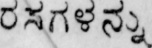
ರಸಗಳನ್ನು
